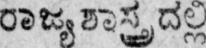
ರಾಜ್ಯಶಾಸ್ತ್ರದಲ್ಲಿ
